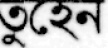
তুহেন
